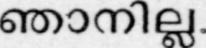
ഞാനില്ല.
